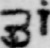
ਤਾਂ
